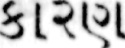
કારણ
